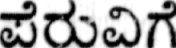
ಪೆರುವಿಗೆ
